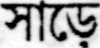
সাড়ে
